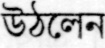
উঠলেন
